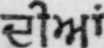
ਦੀਆਂ
